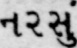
નરસું
